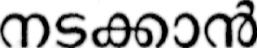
നടക്കാന്‍
